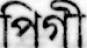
পিগী
